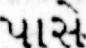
પાસે
